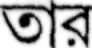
তার
